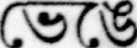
ভেঙে
